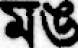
মঙ
